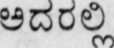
ಅದರಲ್ಲಿ
